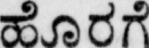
ಹೊರಗೆ
